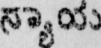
ನ್ಯಾಯ
